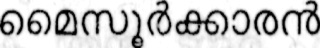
മൈസൂര്‍ക്കാരന്‍
